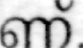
ണ്.
